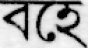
বহে
